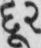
દૂર
